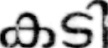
കടി
